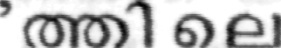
'ത്തിലെ
